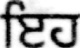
ਇਹ
